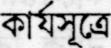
কার্যসূত্রে
